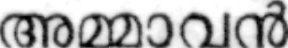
അമ്മാവന്‍
